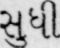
સુધી
